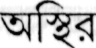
অস্থির
